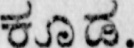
ಕೂಡ,
